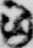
છે
